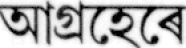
আগ্রহেৰে
